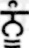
ਨੂੰ
